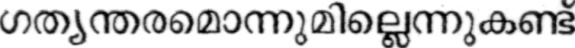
ഗത്യന്തരമൊന്നുമില്ലെന്നുകണ്ട്
